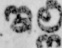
ಇಲ್ಲಿ
